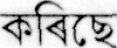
কৰিছে
